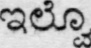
ಇಲ್ವೊ
